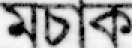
মচাক
